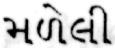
મળેલી
